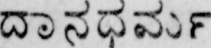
ದಾನಧರ್ಮ
